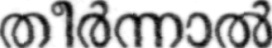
തീര്‍ന്നാല്‍
